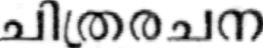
ചിത്രരചന
